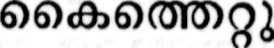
കൈത്തെറ്റു
